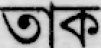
তাক
